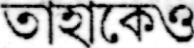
তাহাকেও
